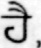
ਹੈ,
